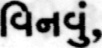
વિનવું,
